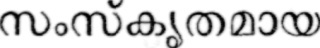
സംസ്കൃതമായ
